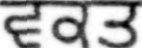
ਵਕਤ
